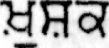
ਖ਼ੁਸ਼ਕ
